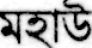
মহাউ
